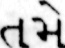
તમે
